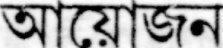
আয়োজন
